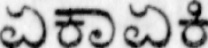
ಏಕಾಏಕಿ
